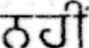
ਨਹੀਂ
